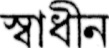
স্বাধীন
